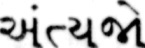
અંત્યજો
